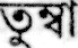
তুম্বা
